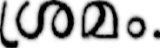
ശ്രമം.
